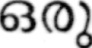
ഒരു
